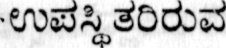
ಉಪಸ್ಥಿತರಿರುವ
